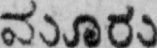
ಮೂರು
